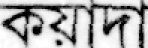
কয়াদা
